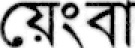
য়েংবা
